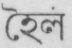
হৈল
